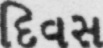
દિવસ
